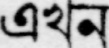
এখন
